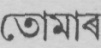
তোমাৰ
